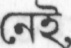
নেই,
